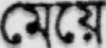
মেয়ে
